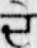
ਦੇ
